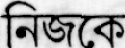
নিজকে
